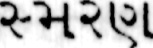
સ્મરણ
